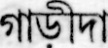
গাড়ীদা
